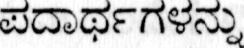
ಪದಾರ್ಥಗಳನ್ನು
